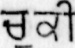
ਚੁਕੀ
